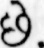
છે.
